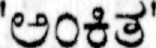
“ಅಂಕಿತ’
